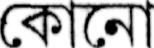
কোনো
